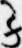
કે
